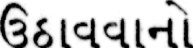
ઉઠાવવાનો
